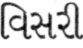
વિસરી
